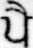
ਪੈ
